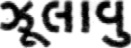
ઝૂલાવુ
